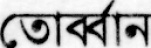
তোর্ব্বান
